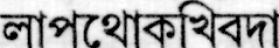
লাপথোকখিবদা
